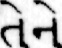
તેને
